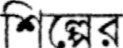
শিল্পের
